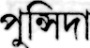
পুন্সিদা
